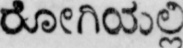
ರೋಗಿಯಲ್ಲಿ
